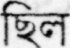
ছিল
